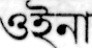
ওইনা
